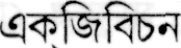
এক্‌জিবিচন
